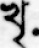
খৃ.
